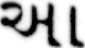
આ
